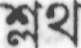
শ্লথ
